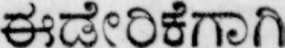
ಈಡೇರಿಕೆಗಾಗಿ
